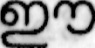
ഈ
